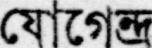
যোগেন্দ্র
